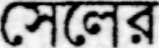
সেলের
